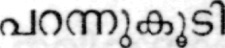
പറന്നുകൂടി
